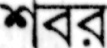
শবর
